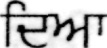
ਦਿਆ
